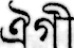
ঐগী
